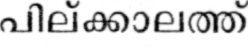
പില്ക്കാലത്ത്
